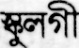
স্কুলগী
